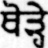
ਥੋੜ੍ਹੇ
